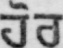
ਹੋਰ
